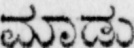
ಮಾಡು
